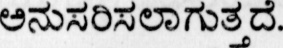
ಅನುಸರಿಸಲಾಗುತ್ತದೆ.
